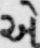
એ
